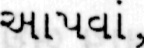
આપવાં,
